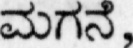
ಮಗನೆ,
